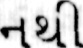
નથી
